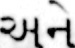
અને
